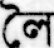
লৈ
